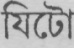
যিটো
